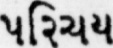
પરિચય
